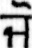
ਜੋ
